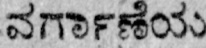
ವರ್ಗಾಣೆಯ
